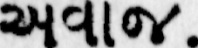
અવાજ.
